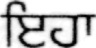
ਇਹਾ
